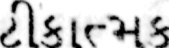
ટીકાત્મક
